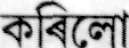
কৰিলো
